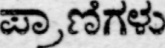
ಪ್ರಾಣಿಗಳು
